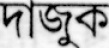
দাজুক
